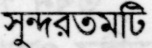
সুন্দরতমটি
